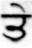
ਤੇ
